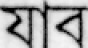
যাব
